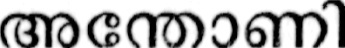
അന്തോണി
